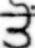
ਤੋਂ
